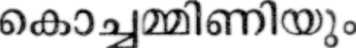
കൊച്ചമ്മിണിയും
